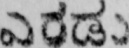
ಎರಡು
